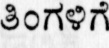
ತಿಂಗಳಿಗೆ
